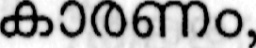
കാരണം,
